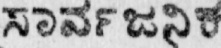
ಸಾರ್ವಜನಿಕ
